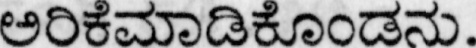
ಅರಿಕೆಮಾಡಿಕೊಂಡನು.
